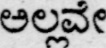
ಅಲ್ಲವೇ
